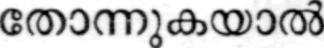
തോന്നുകയാല്‍
